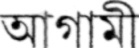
আগামী
